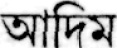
আদিম
